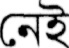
নেই
